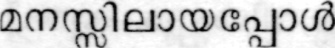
മനസ്സിലായപ്പോള്‍
